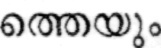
ത്തെയും
